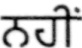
ਨਹੀਂ
